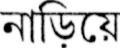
নাড়িয়ে
